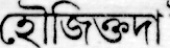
হৌজিক্তদা
